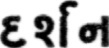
દર્શન
